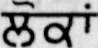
ਲੋਕਾਂ
